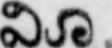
ಮೀ.
